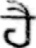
ਹੈ
